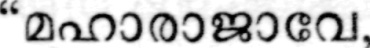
“മഹാരാജാവേ,
